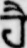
ਹੈ
